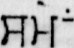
ਸਮੇਂ
